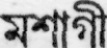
মশাগী
